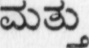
ಮತ್ತು
